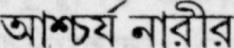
আশ্চর্য নারীর
